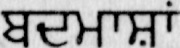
ਬਦਮਾਸ਼ਾਂ
